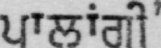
ਪਾਲਾਂਗੀ'
